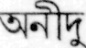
অনীদু
